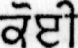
ਕੋਈ
